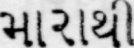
મારાથી
